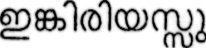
ഇങ്കിരിയസ്സു
